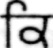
ਕਿ
